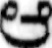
ಆ
